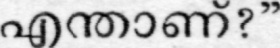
എന്താണ്?”
